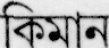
কিমান
